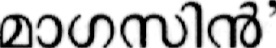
മാഗസിന്‍’
